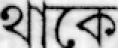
থাকে
